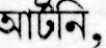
আর্টনি,
